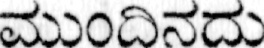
ಮುಂದಿನದು
